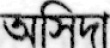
অসিদা
